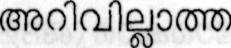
അറിവില്ലാത്ത
